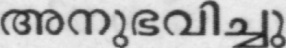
അനുഭവിച്ചു
